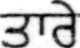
ਤਾਰੇ
